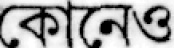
কোনেও
